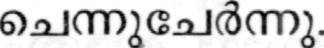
ചെന്നുചേര്‍ന്നു.
